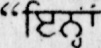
''ਇਨ੍ਹਾਂ
